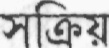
সক্রিয়
